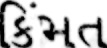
કિંમત
